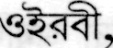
ওইরবী,
